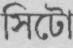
সিটো
